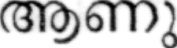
ആണു
